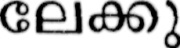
ലേക്കു
